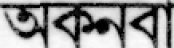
অকনবা
